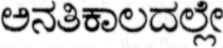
ಅನತಿಕಾಲದಲ್ಲೇ
